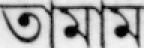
তামাম
